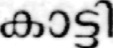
കാട്ടി
